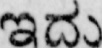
ಇದು
